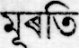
মূৰতি
